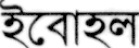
ইবোহল
